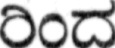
ರಿಂದ
